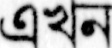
এখন
